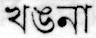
খঙনা
